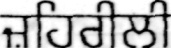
ਜ਼ਹਿਰੀਲੀ
